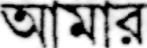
আমার
